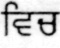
ਵਿਚ
